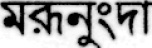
মরূনুংদা
